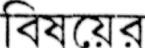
বিষয়ের
